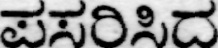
ಪಸರಿಸಿದ
